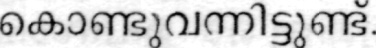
കൊണ്ടുവന്നിട്ടുണ്ട്
